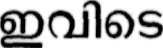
ഇവിടെ
